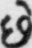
છે
